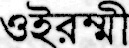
ওইরম্মী
